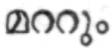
മററും
